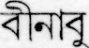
বীনাবু
